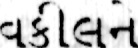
વકીલને
